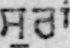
ਸੁਰਾਂ
